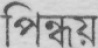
পিন্ধয়
